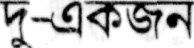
দু-একজন
